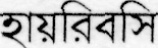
হায়রিবসি
